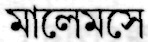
মালেমসে
